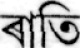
ৰাতি
